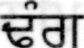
ਢੰਗ
